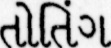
તોતિંગ
